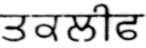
ਤਕਲੀਫ
